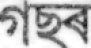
গছৰ
